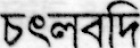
চৎলবদি
